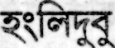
হংলিদুবু
